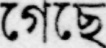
গেছে
